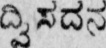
ದ್ವಿಸದನ
